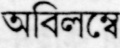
অবিলম্বে
